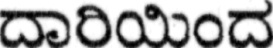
ದಾರಿಯಿಂದ
